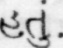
હતું.
